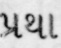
પ્રથા
